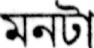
মনটা
